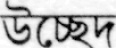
উচ্ছেদ
